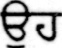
ਉਹ
